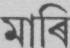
মাৰি
